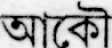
আকৌ
